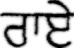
ਰਾਏ
